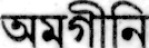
অমগীনি
